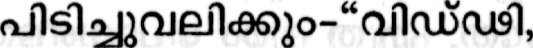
പിടിച്ചുവലിക്കും-“വിഡ്ഢി,
